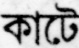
কাটে
